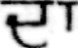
ਦਾ
